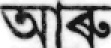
আৰু
